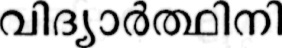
വിദ്യാര്‍ത്ഥിനി
